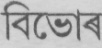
বিভোৰ
